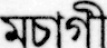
মচাগী
